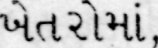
ખેતરોમાં,
